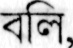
বলি,
